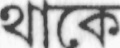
থাকে
